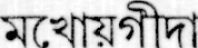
মখোয়গীদা
